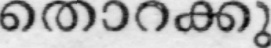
തൊറക്കു
